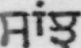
ਸਾਂਝ
